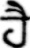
ਹੈ
